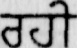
ਰਹੀ
